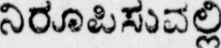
ನಿರೂಪಿಸುವಲ್ಲಿ
